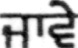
ਜਾਵੇ
